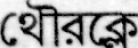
থৌরক্লে
